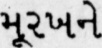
મૂરખને
